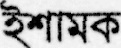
ইশামক
